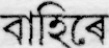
বাহিৰে
